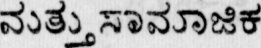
ಮತ್ತುಸಾಮಾಜಿಕ
